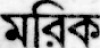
মরিক
